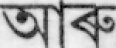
আৰু
